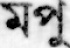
মপু
